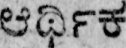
ಆರ್ಥಿಕ
